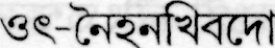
ওৎ-নৈহনখিবদো
